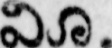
ಮೀ.
